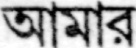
আমার
